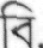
বি.
